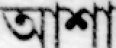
আশা
